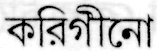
করিগীনো
